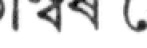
ভাস্বৰ
